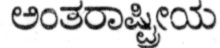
ಅಂತರಾಷ್ಟ್ರೀಯ
